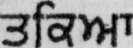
ਤਕਿਆ
